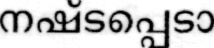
നഷ്ടപ്പെടാ
